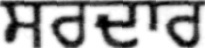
ਸਰਦਾਰ
